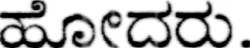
ಹೋದರು.
